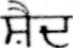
ਸ਼ੈਦ
